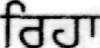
ਰਿਹਾ
